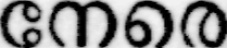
നേരെ
